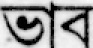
ভাব
